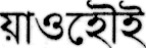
য়াওহৌই
